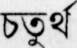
চতুর্থ
